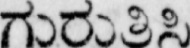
ಗುರುತಿಸಿ
